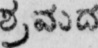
ಶ್ರಮದ
